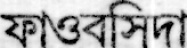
ফাওবসিদা
